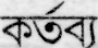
কর্তব্য
